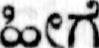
ಹೀಗೆ
